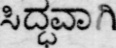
ಸಿದ್ಧವಾಗಿ
